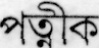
পত্নীক
